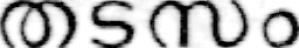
തടസം
